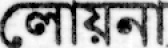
লোয়না
